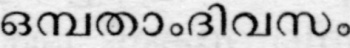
ഒമ്പതാംദിവസം
